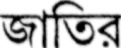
জাতির
